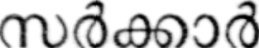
സര്‍ക്കാര്‍
